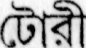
টোরী
